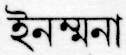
ইনম্মনা
